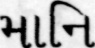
માનિ
